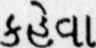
કહેવા
